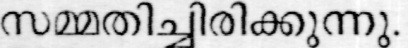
സമ്മതിച്ചിരിക്കുന്നു.
